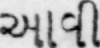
આવી
